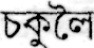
চকুলৈ
